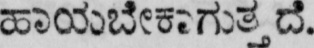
ಹಾಯಬೇಕಾಗುತ್ತದೆ.
